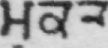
ਮੁਕਤ
